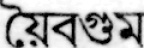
য়ৈবগুম
